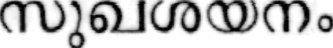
സുഖശയനം
